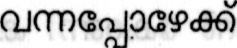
വന്നപ്പോഴേക്ക്
